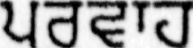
ਪਰਵਾਹ
